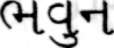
ભુવન
